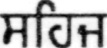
ਸਹਿਜ
